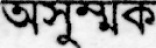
অসুম্মক
